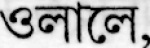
ওলালে,
